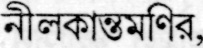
নীলকান্তমণির,
